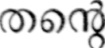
തന്റെ
